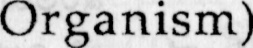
Organism)
